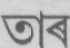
তাৰ
